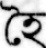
হৈ
